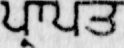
ਪ੍ਰਾਪਤ
